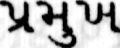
પ્રમુખ
